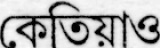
কেতিয়াও
